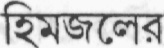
হিমজলের
